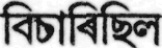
বিচাৰিছিল
